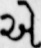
એ
